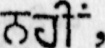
ਨਹੀਂ,
